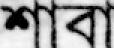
শাবা
